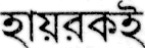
হায়রকই
